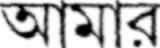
আমার
